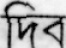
দিব
